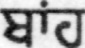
ਬਾਂਹ
